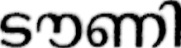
ടൌണി
